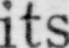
its
